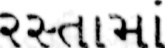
રસ્તામાં
